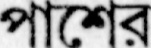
পাশের
